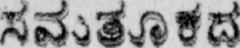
ಸಮತೂಕದ
